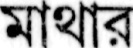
মাথার
